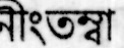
নীংতম্বা
